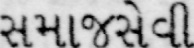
સમાજસેવી
